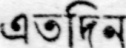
এতদিন
